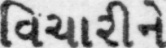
વિચારીને
